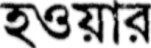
হওয়ার
